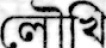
লৌখি
